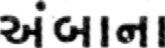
અંબાના
